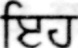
ਇਹ
